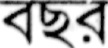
বছর
